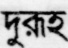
দুরূহ
